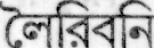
লৈরিবনি
